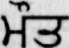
ਮੌਤ
